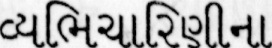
વ્યભિચારિણીના
